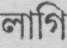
লাগি
